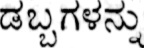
ಡಬ್ಬಗಳನ್ನು
